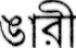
ঙারী
